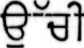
ਉੱਚੀ
